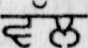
ਵੱਲ
